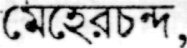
মেহেরচন্দ,
